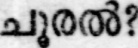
ചൂരല്‍?
